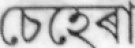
চেহেৰা
